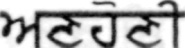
ਅਣਹੋਣੀ
